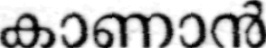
കാണാന്‍
